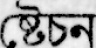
ষ্টেচন
